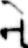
ને
